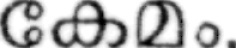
കേമം.
